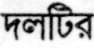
দলটির
